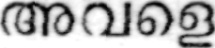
അവളെ
